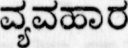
ವ್ಯವಹಾರ
